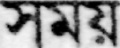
সময়
